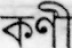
কণী
